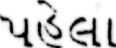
પહેલા
